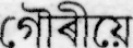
গৌৰীয়ে
